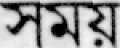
সময়
